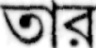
তার
